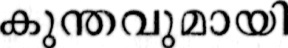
കുന്തവുമായി
